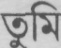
তুমি
